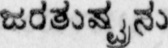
ಜರತುಷ್ಟ್ರನು
